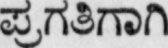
ಪ್ರಗತಿಗಾಗಿ
